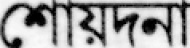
শোয়দনা
